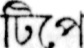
টিপে
